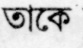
তাকে
